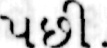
પછી.
